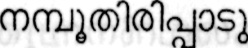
നമ്പൂതിരിപ്പാടു
